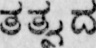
ತತ್ವದ
